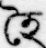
হৈ
